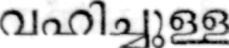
വഹിച്ചുള്ള
